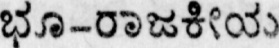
ಭೂ-ರಾಜಕೀಯ
